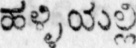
ಹಳ್ಳಿಯಲ್ಲಿ
